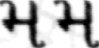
મમ
